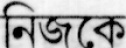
নিজকে
